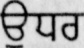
ਉਧਰ
